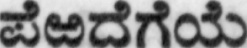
ಪೆಱದೆಗೆಯೆ
